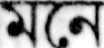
মনে
